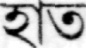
হাত
